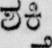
ಶಕ್ತಿ
